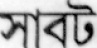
সাবট
